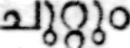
ചുറ്റും
